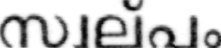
സ്വല്പം
